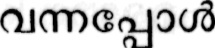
വന്നപ്പോള്‍
